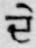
ਦੇ
